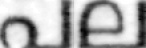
പല
